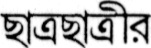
ছাত্রছাত্রীর
